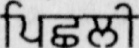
ਪਿਛਲੀ
